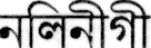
নলিনীগী
